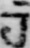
ਹੋ
